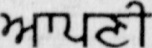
ਆਪਣੀ
